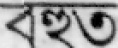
বহুত
